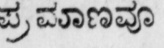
ಪ್ರಮಾಣವೂ
